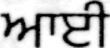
ਆਈ
